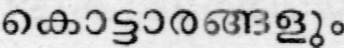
കൊട്ടാരങ്ങളും
